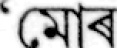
'মোৰ
